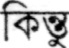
কিন্তু
